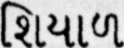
શિયાળ
